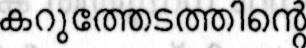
കറുത്തേടത്തിന്റെ
